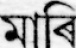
মাৰি
